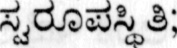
ಸ್ವರೂಪಸ್ಥಿತಿ;
